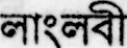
লাংলবী
